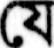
যে
